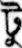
টু
